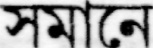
সমানে
